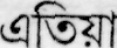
এতিয়া
